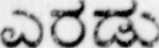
ಎರಡು
